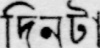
দিনটা
